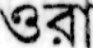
ওরা
